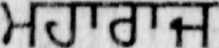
ਮਹਾਰਾਜ
